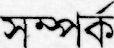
সম্পর্ক
